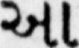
આ
